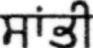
ਸਾਂਭੀ
